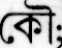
কৌ;
